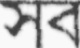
সব
